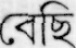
বেছি
